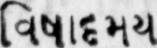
વિષાદમય
